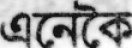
এনেকৈ
